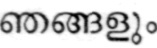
ഞങ്ങളും
